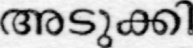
അടുക്കി
